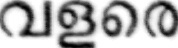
വളരെ
